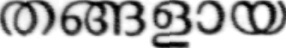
തങ്ങളായ
